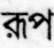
রূপ
